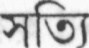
সত্যি
